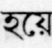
হয়ে
